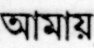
আমায়
